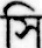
সি
